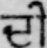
ਦੀ
